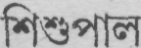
শিশুপাল
